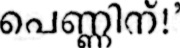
പെണ്ണിന്!’
